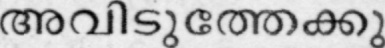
അവിടുത്തേക്കു
